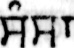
ਸੰਸਾ
